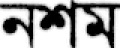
নশম
